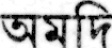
অমদি
